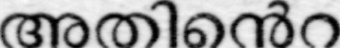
അതിന്റെ
